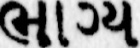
ભાગ્ય
